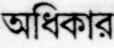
অধিকার
